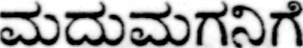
ಮದುಮಗನಿಗೆ
